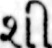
શી
